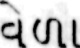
વેળા
